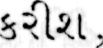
કરીશ,
